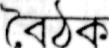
বৈঠক
